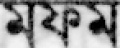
মফম
